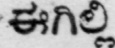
ಈಗಿಲ್ಲಿ
